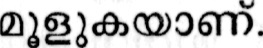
മൂളുകയാണ്.
